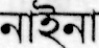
নাইনা
